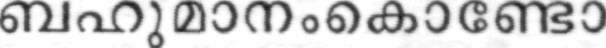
ബഹുമാനംകൊണ്ടോ
